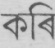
কৰি
